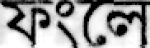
ফংলে
